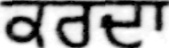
ਕਰਦਾ
